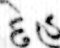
દેહ
